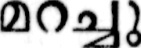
മറച്ചു
